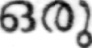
ഒരു
